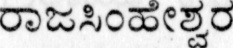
ರಾಜಸಿಂಹೇಶ್ವರ
